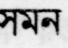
সমন
